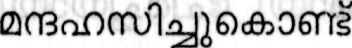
മന്ദഹസിച്ചുകൊണ്ട്
